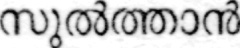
സുല്‍ത്താന്‍
